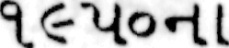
૧૯૫૦ના
